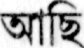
আছি
